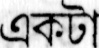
একটা
